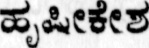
ಹೃಷೀಕೇಶ
